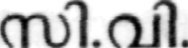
സി.വി.
